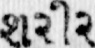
શરીર
